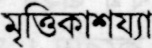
মৃত্তিকাশয্যা
